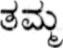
ತಮ್ಮ
